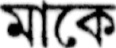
মাকে
